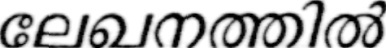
ലേഖനത്തില്‍
